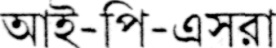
আই-পি-এসরা
